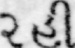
રહી
